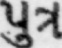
પુત્ર
